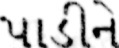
પાડીને
